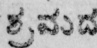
ಶ್ರಮದ
